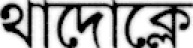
থাদোক্লে
